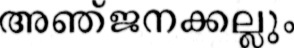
അഞ്ജനക്കല്ലും
